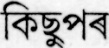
কিছুপৰ
